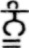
ਨੂੰ
